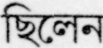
ছিলেন
